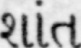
શાંત
